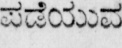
ಪಡೆಯುವ
